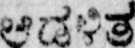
ಆಡಳಿತ
